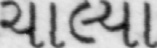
ચાલ્યા
